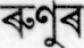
ৰুণুৰ
